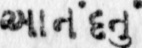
આનંદનું
